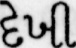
દેખી
